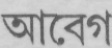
আবেগ
